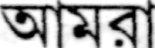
আমরা
